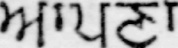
ਆਪਣਾ
